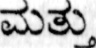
ಮತ್ತು
